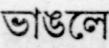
ভাঙলে
